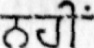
ਨਹੀਂ
